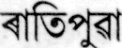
ৰাতিপুৱা
